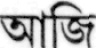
আজি
